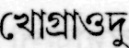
খোগ্রাওদু
